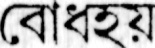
বোধহয়
